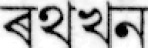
ৰথখন
